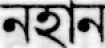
নহান
